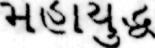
મહાયુદ્ધ
